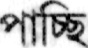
পাচ্ছি
